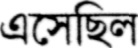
এসেছিল
